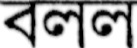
বলল
